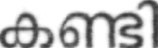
കണ്ടി
